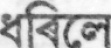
ধৰিলে
